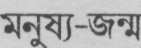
মনুষ্য-জন্ম
